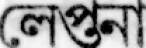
লেপ্তনা
